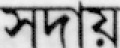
সদায়
